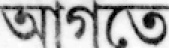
আগতে
